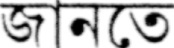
জানতে
